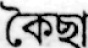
কৈছা
